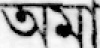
অমা
